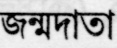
জন্মদাতা
